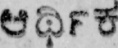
ಆರ್ಥಿಕ
